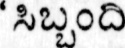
‘ಸಿಬ್ಬಂದಿ
